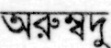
অরুম্বদু
